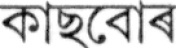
কাছবোৰ
